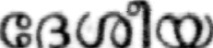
ദേശീയ
